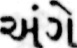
અંગે
